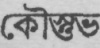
কৌস্তুভ
